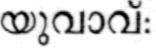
യുവാവ്:
